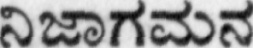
ನಿಜಾಗಮನ
